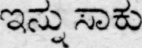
ಇನ್ನುಸಾಕು
